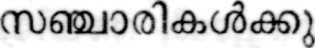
സഞ്ചാരികള്‍ക്കു
